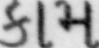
કામ
